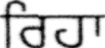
ਰਿਹਾ
